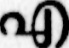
എ
